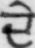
ਦੇ
